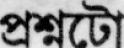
প্রশ্নটো
